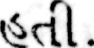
હતી.
